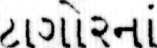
ટાગોરનાં
